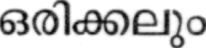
ഒരിക്കലും
